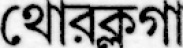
থোরক্লগা
